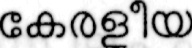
കേരളീയ
